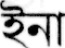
ইনা
